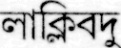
লাক্লিবদু
